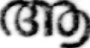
ആ
